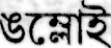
ঙম্লোই
